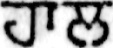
ਹਾਲ
